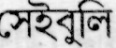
সেইবুলি
